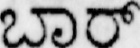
ಬಾರ್
